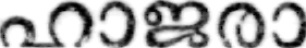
ഹാജരാ
